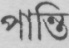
পান্তি
